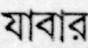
যাবার
